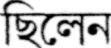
ছিলেন
